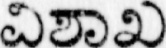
ವಿಶಾಖ
